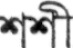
শশী
